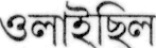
ওলাইছিল
